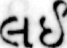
લઈ
